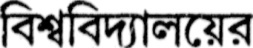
বিশ্ববিদ্যালয়ের
